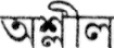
অশ্লীল
